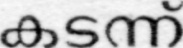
കടന്ന്
